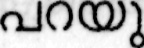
പറയു
